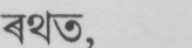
ৰথত,
